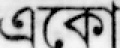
একো
